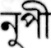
নুপী
